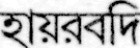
হায়রবদি
